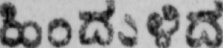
ಹಿಂದುಳಿದ
